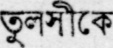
তুলসীকে
